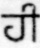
ਹੀ
